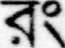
রং
